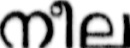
നീല
